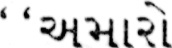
"અમારો
